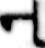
ન
